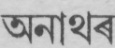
অনাথৰ
